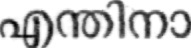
എന്തിനാ
